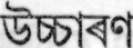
উচ্চাৰণ
